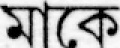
মাকে
